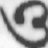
ও
